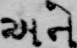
અને
